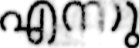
എന്നു
